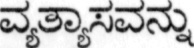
ವ್ಯತ್ಯಾಸವನ್ನು
